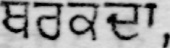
ਥਰਕਦਾ,
